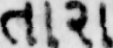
તારા
